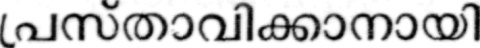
പ്രസ്താവിക്കാനായി
